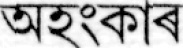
অহংকাৰ
